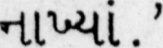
નાખ્યાં.'
